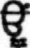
ਊਂ
